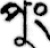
পুং
